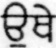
ਉਥੇ
